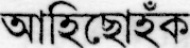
আহিছোহঁক
